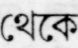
থেকে
